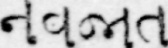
નવજાત
